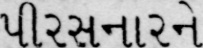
પીરસનારને
